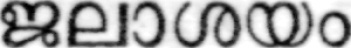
ജലാശയം
